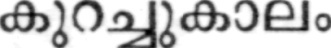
കുറച്ചുകാലം
